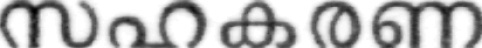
സഹകരണ
